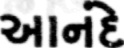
આનંદે
